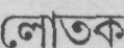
লোতক
